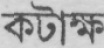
কটাক্ষ
